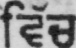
ਵਿੱਚ
